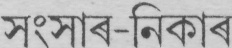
সংসাৰ-নিকাৰ
